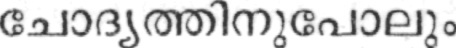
ചോദ്യത്തിനുപോലും
